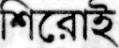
শিরোই
